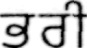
ਭਰੀ
